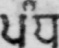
ਪੰਧ
